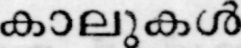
കാലുകള്‍
